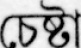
চেষ্টা
